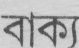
বাক্য
